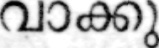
വാക്കു
